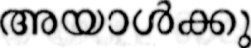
അയാള്‍ക്കു
